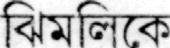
ঝিমলিকে
